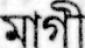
মাগী
